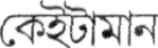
কেইটামান
